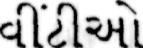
વીંટીઓ
